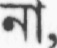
না,
